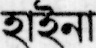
হাইনা
